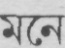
মনে
